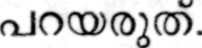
പറയരുത്.
